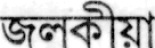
জলকীয়া
